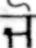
ਜੋ
